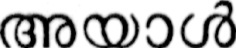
അയാള്‍
